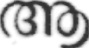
ആ
